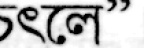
চৎলে”
